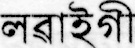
লৱাইগী
